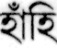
হাঁহি
